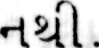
નથી.
